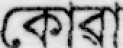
কোৱা
